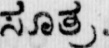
ಸೂತ್ರ.
